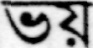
ভয়
